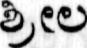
ಶ್ರೀಲ
